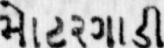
મોટરગાડી
